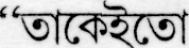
"তাকেইতো
